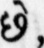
છે,
